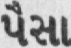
પૈસા
